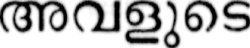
അവളുടെ
